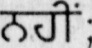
ਨਹੀਂ;
